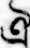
ঐ
